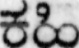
ಕಹಿ
